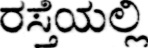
ರಸ್ತೆಯಲ್ಲಿ
